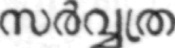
സര്‍വ്വത്ര
